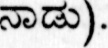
ನಾಡು).
